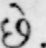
છે.
